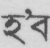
হ'ব
